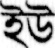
ইউ
